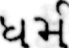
ધર્મ
